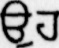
ਉਹ
